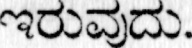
ಇರುವುದು.
